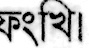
ফংখি।
